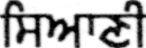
ਸਿਆਣੀ
